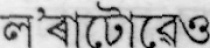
ল'ৰাটোৱেও
